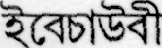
ইবেচাউবী
